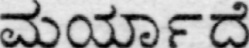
ಮರ್ಯಾದೆ
